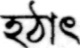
হঠাৎ
